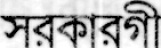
সরকারগী
